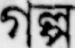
গল্প
